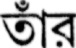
তাঁর
